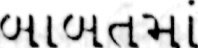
બાબતમાં
